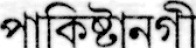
পাকিষ্টানগী
